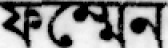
ফম্মেন
